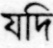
যদি
